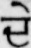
ਦੇ
